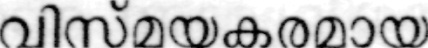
വിസ്മയകരമായ
